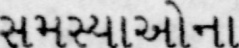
સમસ્યાઓના
